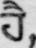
ਹੈ,
